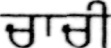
ਚਾਚੀ
